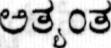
ಅತ್ಯಂತ
